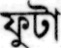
ফুটা
